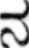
ನ
